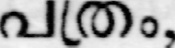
പത്രം,
